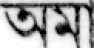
অমা
